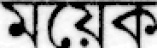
ময়েক
